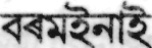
বৰমইনাই
